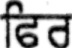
ਫਿਰ
